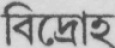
বিদ্ৰোহ
